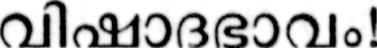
വിഷാദഭാവം!
